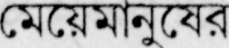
মেয়েমানুষের
